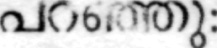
പറഞ്ഞു:
